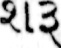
શરૂ
